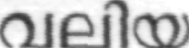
വലിയ
